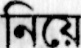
নিয়ে
